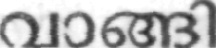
വാങ്ങി
